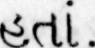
હતાં.
